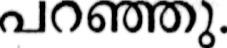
പറഞ്ഞു.
